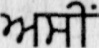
ਅਸੀਂ
